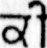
ਕੀ
